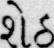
શેઠ
